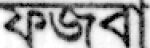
ফজবা
